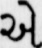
એ
